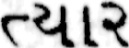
ત્યાર
